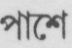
পাশে
